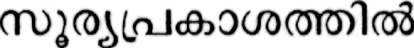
സൂര്യപ്രകാശത്തില്‍
